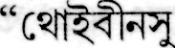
“থোইবীনসু
